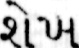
શેખ
